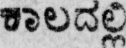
ಕಾಲದಲ್ಲಿ
